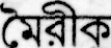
মৈরীক
